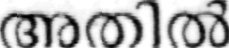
അതില്‍
